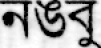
নঙবু
